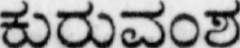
ಕುರುವಂಶ
